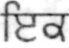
ਇਕ
